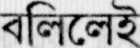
বলিলেই
